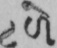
ટળે
